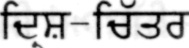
ਦ੍ਰਿਸ਼-ਚਿੱਤਰ
